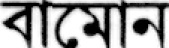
বামোন
